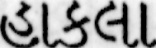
હાકલા
